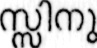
സ്സിനു
